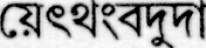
য়েৎথংবদুদা
